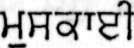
ਮੁਸਕਾਈ
